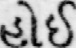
હોઈ
